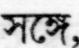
সঙ্গে,
